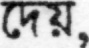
দেয়,
